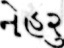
નેહરુ
